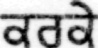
ਕਰਕੇ
